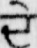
ਦੇ
